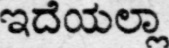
ಇದೆಯಲ್ಲಾ
